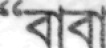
"বাবা
